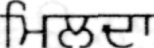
ਮਿਲਦਾ
